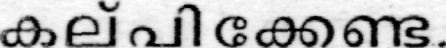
കല്പിക്കേണ്ട.
